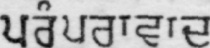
ਪਰੰਪਰਾਵਾਦ
